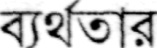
ব্যর্থতার
